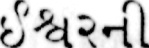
ઈશ્વરની
